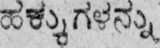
ಹಕ್ಕುಗಳನ್ನು
